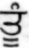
ਤੂੰ
